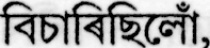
বিচাৰিছিলোঁ,
